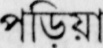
পড়িয়া
